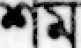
শম
